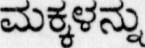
ಮಕ್ಕಳನ್ನು
